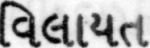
વિલાયત
